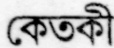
কেতকী
